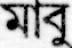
মাবু
